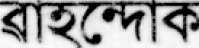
ৱাহন্দোক
